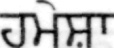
ਹਮੇਸ਼ਾ
